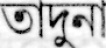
তাদুনা
